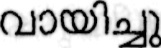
വായിച്ചു
